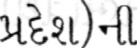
પ્રદેશ)ની
